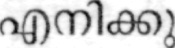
എനിക്കു
